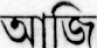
আজি
